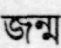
জন্ম
